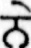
ਨੇ
